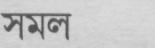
সমল
